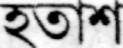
হতাশ
